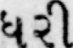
ધરી
